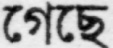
গেছে
